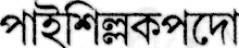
পাইশিল্লকপদো
